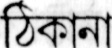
ঠিকানা
